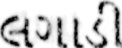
લગાડી
